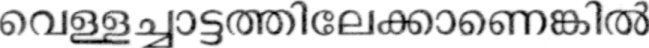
വെള്ളച്ചാട്ടത്തിലേക്കാണെങ്കില്‍
